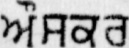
ਔਸਕਰ
